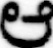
ಆ
